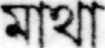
মাথা
